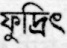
ফুদ্রিৎ
